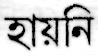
হায়নি
